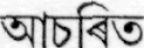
আচৰিত
